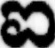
ಐ
